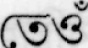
তেওঁ
